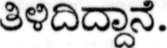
ತಿಳಿದಿದ್ದಾನೆ.
